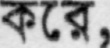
করে,
